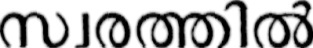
സ്വരത്തില്‍
